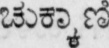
ಚುಕ್ಕಾಣಿ
